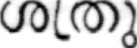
ശത്രു
